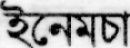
ইনেমচা
